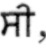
ਸੀ,
